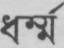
ধৰ্ম্ম
